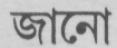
জানো
